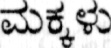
ಮಕ್ಕಳು
